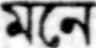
মনে
